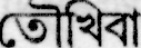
তৌখিবা
